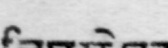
ਵਿਸ਼ਲੇਸ਼ਣ
